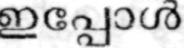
ഇപ്പോള്‍
